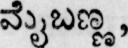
ಮೈಬಣ್ಣ,
